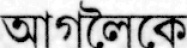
আগলৈকে
